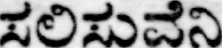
ಸಲಿಸುವೆನಿ
